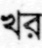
খর
